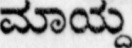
ಮಾಯ್ದ
